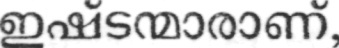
ഇഷ്ടന്മാരാണ്,
